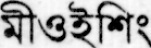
মীওইশিং
